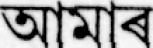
আমাৰ
